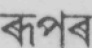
ৰূপৰ
